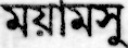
ময়ামসু
